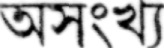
অসংখ্য
